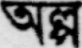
অল্প
